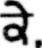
ਕੇ,
